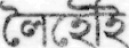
লৈহৌই
